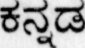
ಕನ್ನಡ
